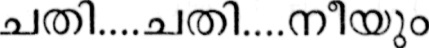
ചതി....ചതി....നീയും
